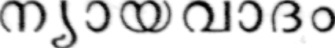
ന്യായവാദം
